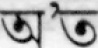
অ'ত
